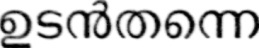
ഉടന്‍തന്നെ
